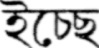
ইচ্ছে
